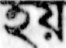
হয়
